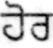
ਹੋਰ
